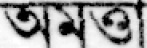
অমত্তা
